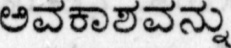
ಅವಕಾಶವನ್ನು
